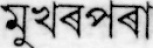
মুখৰপৰা
